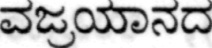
ವಜ್ರಯಾನದ
